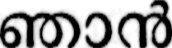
ഞാന്‍
